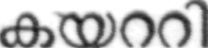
കയററി
